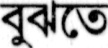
বুঝতে
